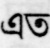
এত
